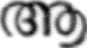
ആ
